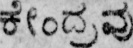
ಕೇಂದ್ರವು
